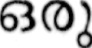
ഒരു
